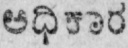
ಅಧಿಕಾರ
